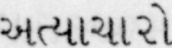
અત્યાચારો
